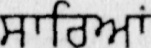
ਸਾਰਿਆਂ
